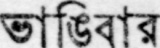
ভাঙিবার
